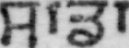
ਸਾਡਾ
